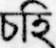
চহি
